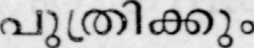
പുത്രിക്കും
